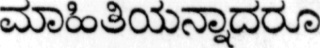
ಮಾಹಿತಿಯನ್ನಾದರೂ
